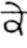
ਕੇ
